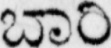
ಬಾರಿ
